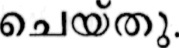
ചെയ്തു.
